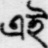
এই
